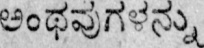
ಅಂಥವುಗಳನ್ನು
